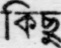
কিছু
